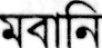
মবানি
